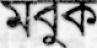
মবুক
